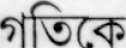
গতিকে
